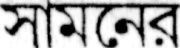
সামনের
